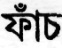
ফাঁচ
